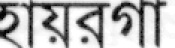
হায়রগা
